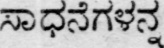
ಸಾಧನೆಗಳನ್ನ
